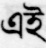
এই
